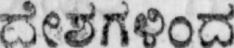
ದೇಶಗಳಿಂದ
